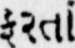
ફરતાં
